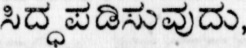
ಸಿದ್ಧಪಡಿಸುವುದು,
